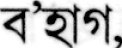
ব'হাগ,
